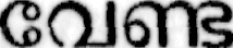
വേണ്ട
